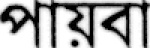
পায়বা
